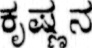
ಕೃಷ್ಣನ
